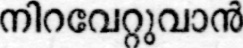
നിറവേറ്റുവാന്‍
